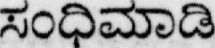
ಸಂಧಿಮಾಡಿ
